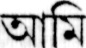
আমি
